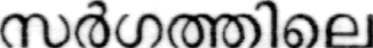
സര്‍ഗത്തിലെ
